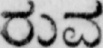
ರುವ
